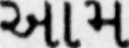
આમ
